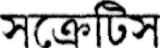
সক্রেটিস
